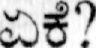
ಏಕೆ?
